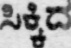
ಸಿಕ್ಕಿದ
